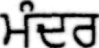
ਮੰਦਰ
